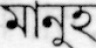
মানুহ
